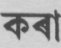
কৰা
